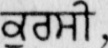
ਕੁਰਸੀ,
